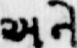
અને
